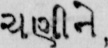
ચણીને,
